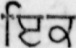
ਇਕ
